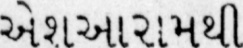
એશઆરામથી
